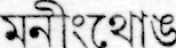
মনীংথোঙ
